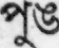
পুঙ
